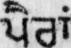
ਪੈਰਾਂ
